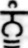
ਨੂੰ
